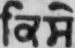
ਕਿਸੇ
